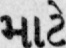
માટે
